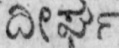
ದೀರ್ಘ
